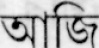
আজি
